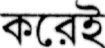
করেই
